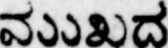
ಮುಖದ
